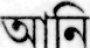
আনি
